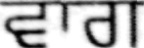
ਵਾਂਗ
